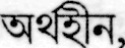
অৰ্থহীন,
